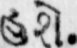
હશે.
